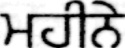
ਮਹੀਨੇ
